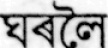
ঘৰলৈ
